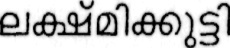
ലക്ഷ്മിക്കുട്ടി
